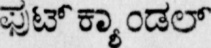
ಫುಟ್‌ಕ್ಯಾಂಡಲ್
